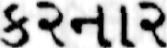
કરનાર
